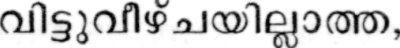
വിട്ടുവീഴ്ചയില്ലാത്ത,
